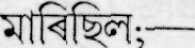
মাৰিছিল;-
